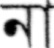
না
